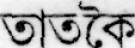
তাতকৈ
